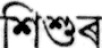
শিশুৰ
